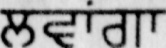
ਲਵਾਂਗਾ
